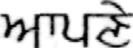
ਆਪਣੇ
